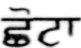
ਛੋਟਾ
